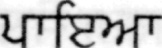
ਪਾਇਆ
